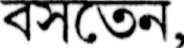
বসতেন,
